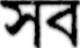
সব
